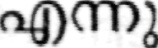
എന്നു
